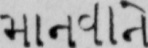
માનવીને
